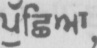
ਪੁੱਛਿਆ,
